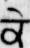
ਕੇ
